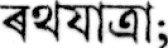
ৰথযাত্রা;
